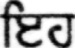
ਇਹ
